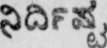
ನಿರ್ದಿಷ್ಟ
